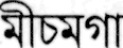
মীচমগা
